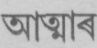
আত্মাৰ
